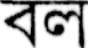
বল
